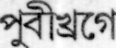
পুবীখ্রগে
